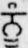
ਨੂੰ
